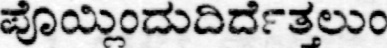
ಪೊಯ್ಲಿಂದುದಿರ್ದೆತ್ತಲುಂ
